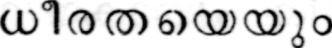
ധീരതയെയും
